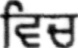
ਵਿਚ
